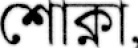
শোক্না,
